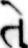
તે
